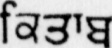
ਕਿਤਾਬ
